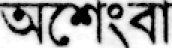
অশেংবা
